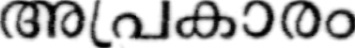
അപ്രകാരം
